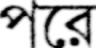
পরে
